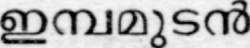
ഇമ്പമുടന്‍
